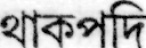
থাকপদি
